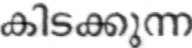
കിടക്കുന്ന
